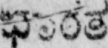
ಭಾರತ
